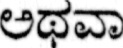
ಅಥವಾ
